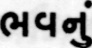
ભવનું
